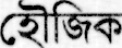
হৌজিক
